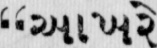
“આખરે
